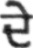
ਦੇ
